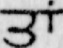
ਤਾਂ
